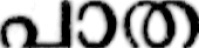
പാത
